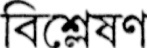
বিশ্লেষণ
